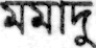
মমাদু
